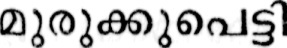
മുരുക്കുപെട്ടി
